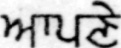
ਆਪਣੇ
